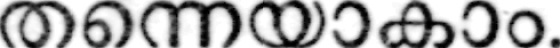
തന്നെയാകാം.
